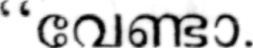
"വേണ്ടാ.
